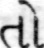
તો
